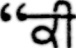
''ਕੀ
